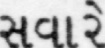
સવારે
